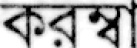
করম্বা
